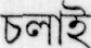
চলাই
